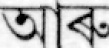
আৰু
